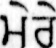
ਮੇਰੇ
